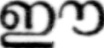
ഈ
